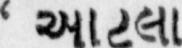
'આટલા
